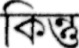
কিন্তু
